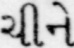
ચીને
